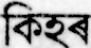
কিহৰ
